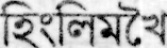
হিংলিমখৈ
